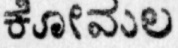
ಕೋಮಲ
